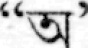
"অ'
